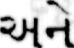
અને
